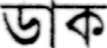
ডাক
